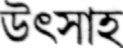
উৎসাহ
